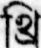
থ্রি
